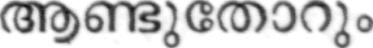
ആണ്ടുതോറും
